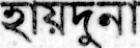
হায়দুনা
